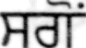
ਸਗੋਂ
